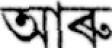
আৰু
